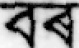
বৰ
